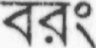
বরং
